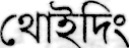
থোইদিং
